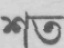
শত
